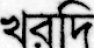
খরদি
